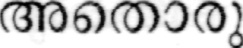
അതൊരു
